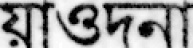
য়াওদনা
